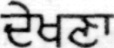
ਦੇਖਣਾ
